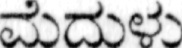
ಮೆದುಳು
